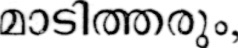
മാടിത്തരും,
